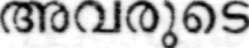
അവരുടെ
